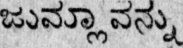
ಜುಮ್ಲಾವನ್ನು
